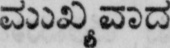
ಮುಖ್ಯವಾದ
